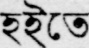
হইতে
